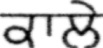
ਕਾਲੇ
